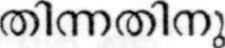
തിന്നതിനു
